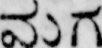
ಮಗ
